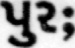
પુર;
